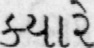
ક્યારે
